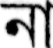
না
